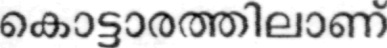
കൊട്ടാരത്തിലാണ്
